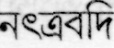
নৎত্রবদি
